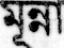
মূন্না
